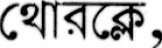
থোরক্লে,
